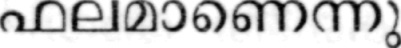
ഫലമാണെന്നു
